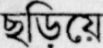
ছড়িয়ে
